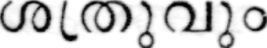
ശത്രുവും
